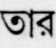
তার
